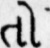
તો
